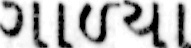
ગાળ્યા
